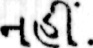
નહીં.
